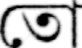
তো
